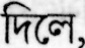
দিলে,
